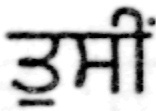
ਤੁਸੀਂ
